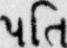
પતિ
